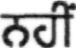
ਨਹੀਂ
